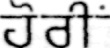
ਹੋਰੀਂ
